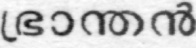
ഭ്രാന്തന്‍
